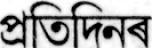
প্রতিদিনৰ
